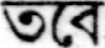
তবে
